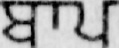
ਬਾਪ
